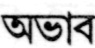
অভাব
